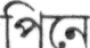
পিনে
